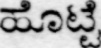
ಹೊಟ್ಟೆ
